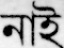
নাই
